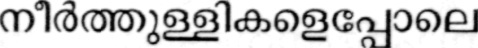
നീര്‍ത്തുള്ളികളെപ്പോലെ
